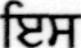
ਇਸ
